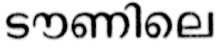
ടൌണിലെ
